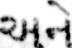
અને
